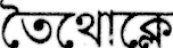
তৈথোক্লে
